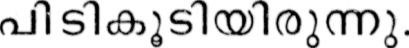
പിടികൂടിയിരുന്നു.
